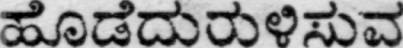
ಹೊಡೆದುರುಳಿಸುವ
